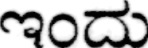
ಇಂದು
